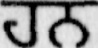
ਹਨ
